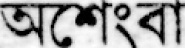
অশেংবা
